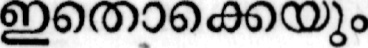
ഇതൊക്കെയും
